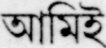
আমিই
